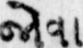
જોવા
